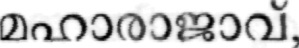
മഹാരാജാവ്,
